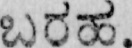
ಬರಹ.
